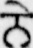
ਨੇ
